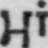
ਮਾਂ
